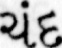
ચંદ
